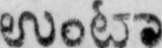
ಉಂಟಾ
